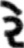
રે
